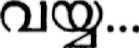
വയ്യ...
